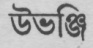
উভঞ্জি
